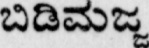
ಬಿಡಿಮಜ್ಜ
